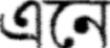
এনে
